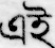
এই
